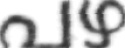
പഴ
